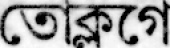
তোক্লগে
